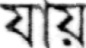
যায়
